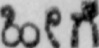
ಹೀಗೆ
